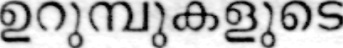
ഉറുമ്പുകളുടെ
